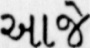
આજે
